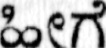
ಹೀಗೆ
